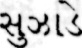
સુઝાડે
